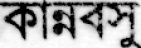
কান্নবসু
